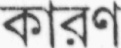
কারণ
